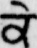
ਕੇ
